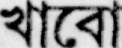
খাবো
